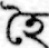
হৈ
